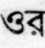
ওর
